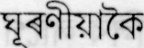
ঘূৰণীয়াকৈ
